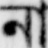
না
